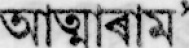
আত্মাৰাম'
